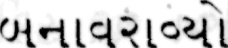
બનાવરાવ્યો
